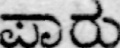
ಪಾರು
